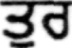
ਤੁਰ
